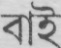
বাই
